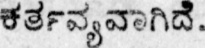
ಕರ್ತವ್ಯವಾಗಿದೆ.
